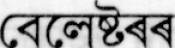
বেলেষ্টৰৰ
